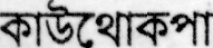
কাউথোকপা
